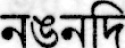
নঙনদি
